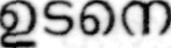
ഉടനെ
